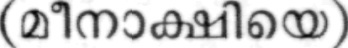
(മീനാക്ഷിയെ)
